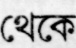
থেকে
